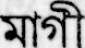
মাগী
